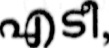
എടീ,
